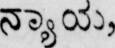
ನ್ಯಾಯ,
